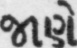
જાણે
